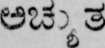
ಅಚ್ಯುತ
